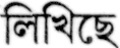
লিখিছে
